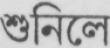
শুনিলে
